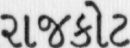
રાજકોટ
